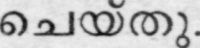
ചെയ്തു.
